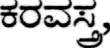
ಕರವಸ್ತ್ರ,
